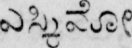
ಎಸ್ಕಿಮೋ
